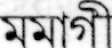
মমাগী
